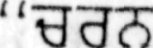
''ਚਰਨ
